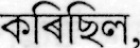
কৰিছিল,
